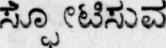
ಸ್ಫೋಟಿಸುವ
